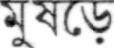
মুষড়ে
